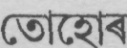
তোহোৰ
